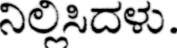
ನಿಲ್ಲಿಸಿದಳು.
